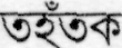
তহঁতক
